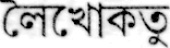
লৈখোকতু
